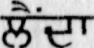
ਲੈਂਦਾ
